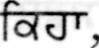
ਕਿਹਾ,
